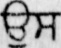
ਉਸ
